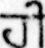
ਹੀ
